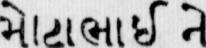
મોટાભાઈને
